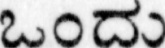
ಒಂದು
